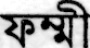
ফম্মী
